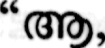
“ആ,
